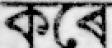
কৰে
